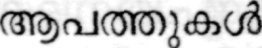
ആപത്തുകള്‍
